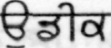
ਉਡੀਕ
